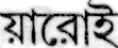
য়ারোই
